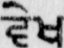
ਵੇਖ
